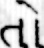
તો
